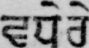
ਵਧੇਰੇ
